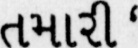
તમારી
